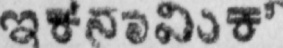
ಇಕನಾಮಿಕ್
